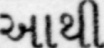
આથી
